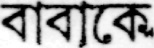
বাবাকে
